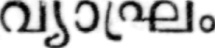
വ്യാഘ്രം
